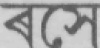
ৰসে
